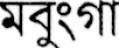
মবুংগা
